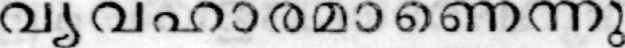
വ്യവഹാരമാണെന്നു
